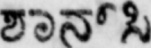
ಶಾನ್‌ಸಿ
